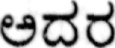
ಅದರ
